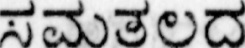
ಸಮತಲದ
